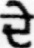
ਦੇ
